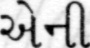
એની
